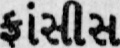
ફ્રાંસીસ
